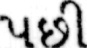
પછી
